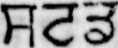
ਸਟਡ
